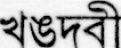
খঙদবী
